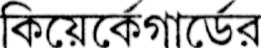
কিয়ের্কেগার্ডের
